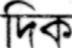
দিক
